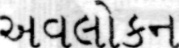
અવલોકન
